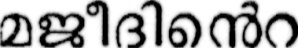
മജീദിന്റെ
